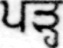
ਪੜ੍ਹ
